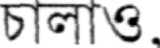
চালাও,
